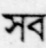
সব
